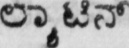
ಲ್ಯಾಟಿನ್
